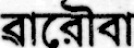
ৱারৌবা
